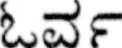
ಓರ್ವ
